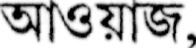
আওয়াজ,
